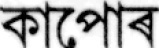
কাপোৰ
